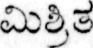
ಮಿಶ್ರಿತ
